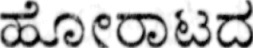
ಹೋರಾಟದ
